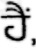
ਹੈਂ,
